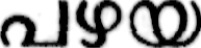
പഴയ
